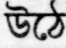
উঠে
